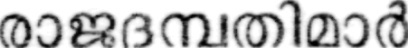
രാജദമ്പതിമാര്‍
